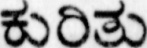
ಕುರಿತು
